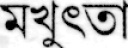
মখুৎতা
